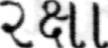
રક્ષા
